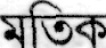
মতিক
